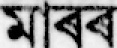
মাৰৰ
